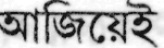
আজিয়েই
